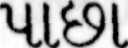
પાછા
